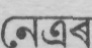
নেত্ৰৰ
